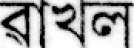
ৱাখল
